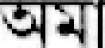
অমা
